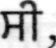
ਸੀ,
